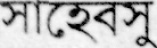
সাহেবসু
